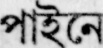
পাইনে
